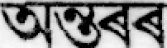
অন্তৰৰ
